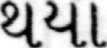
થયા
